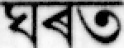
ঘৰত
